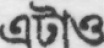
এটাও
